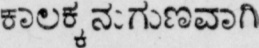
ಕಾಲಕ್ಕನುಗುಣವಾಗಿ
